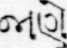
જાણે
